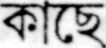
কাছে
